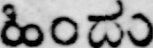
ಹಿಂದು
